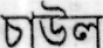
চাউল
